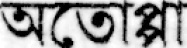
অতোপ্পা
